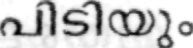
പിടിയും
